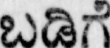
ಬಡಿಗೆ
